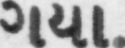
ગયા.
